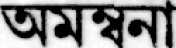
অমম্বনা
